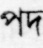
পদ
